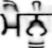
ਮੈਨੂੰ
